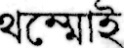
থম্মোই
